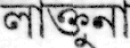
লাক্তুনা
